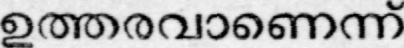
ഉത്തരവാണെന്ന്
